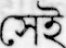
সেই
